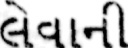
લેવાની
